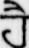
ਹੈ
